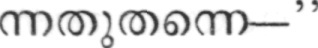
ന്നതുതന്നെ-"
